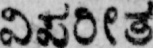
ವಿಪರೀತ
